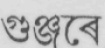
গুঞ্জৰে
